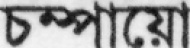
চম্পায়ো
